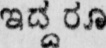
ಇದ್ದರೂ
